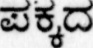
ಪಕ್ಕದ
